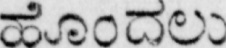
ಹೊಂದಲು
